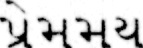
પ્રેમમય
